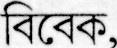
বিবেক,
